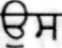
ਉਸ
